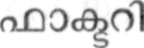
ഫാക്ടറി
